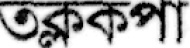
তক্লকপা
